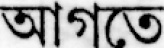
আগতে
